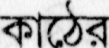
কাঠের
